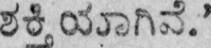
ಶಕ್ತಿಯಾಗಿವೆ.’
